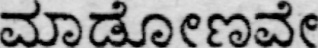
ಮಾಡೋಣವೇ
